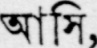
আসি,
